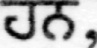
ਹਨ,
